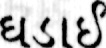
ઘડાઈ
